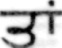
ਤਾਂ
